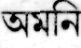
অমনি
